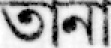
তানা
